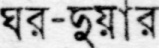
ঘর-দুয়ার
